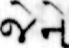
જેને
